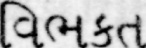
વિભક્ત
